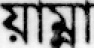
য়াম্না
